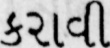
કરાવી
